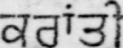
ਕਰਾਂਤੀ
